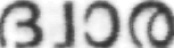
ദ്വാര
